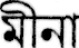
মীনা
